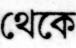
থেকে
